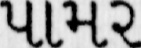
પામર
